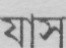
যাস
